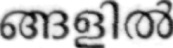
ങ്ങളില്‍
